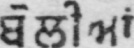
ਬੋਲੀਆਂ
